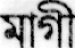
মাগী
